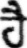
ਹੈ
